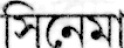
সিনেমা
